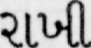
રાખી
